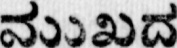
ಮುಖದ
